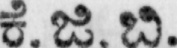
ಕೆ.ಜಿ.ಬಿ.
